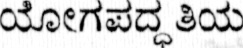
ಯೋಗಪದ್ಧತಿಯ
